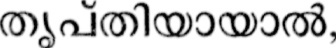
തൃപ്തിയായാല്‍,
